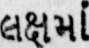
લક્ષમાં
